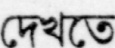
দেখতে
